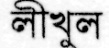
লীখুল
